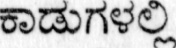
ಕಾಡುಗಳಲ್ಲಿ
